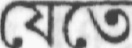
যেতে
